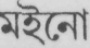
মইনো
